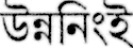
উন্ননিংই
